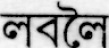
লবলৈ
